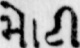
મોટી
